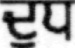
ਦੁਧ
